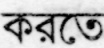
করতে
